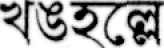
খঙহল্লে
